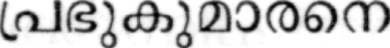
പ്രഭുകുമാരനെ
